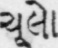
ચૂલો
